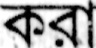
করা
